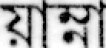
য়াম্না
